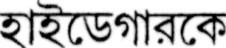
হাইডেগারকে
